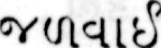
જળવાઈ
